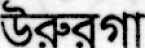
উরুরগা
